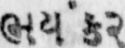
ભયંકર
